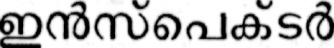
ഇന്‍സ്പെക്ടര്‍
